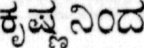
ಕೃಷ್ಣನಿಂದ
